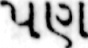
પણ
